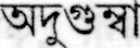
অদুগুম্বা
